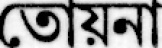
তোয়না
